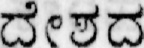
ದೇಶದ
